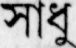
সাধু
